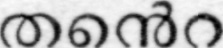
തന്റെ
